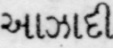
આઝાદી
